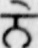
ਨੇ
